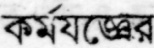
কর্মযজ্ঞের
